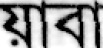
য়াবা
